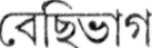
বেছিভাগ
